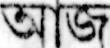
আজ
